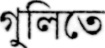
গুলিতে
